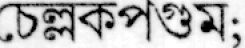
চেল্লকপগুম;
